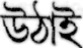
উঠাই
